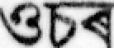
ওচৰ
